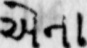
એના
